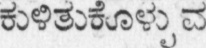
ಕುಳಿತುಕೊಳ್ಳುವ
